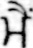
ਮੈਂ
